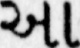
આ
